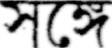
সঙ্গে
